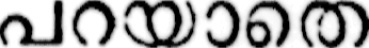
പറയാതെ
